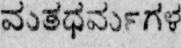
ಮತಧರ್ಮಗಳ
